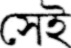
সেই
